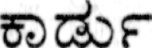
ಕಾರ್ಡು
